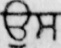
ਉਸ
